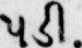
પડી.
